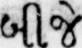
બીજે
